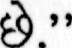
છે."
